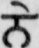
ਨੇ
